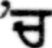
'ਚ
